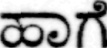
ಹಾಗೆ
